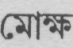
মোক্ষ
